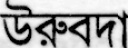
উরুবদা
